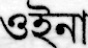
ওইনা
